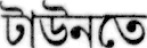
টাউনতে
